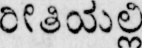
ರೀತಿಯಲ್ಲಿ
